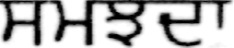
ਸਮਝਦਾ
